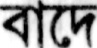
বাদে
